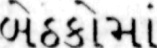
બેઠકોમાં
